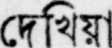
দেখিয়া
